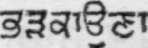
ਭੜਕਾਉਣਾ
